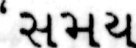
'સમય
